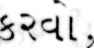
કરવો,
